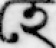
হে
